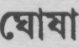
ঘোষা
